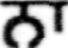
ਨਾ
